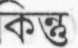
কিন্তু
